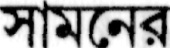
সামনের
